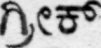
ಗ್ರೀಕ್
